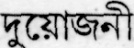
দুয়োজনী
